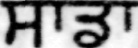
ਸਾਡਾ
